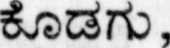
ಕೊಡಗು,
